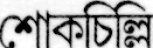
শোকচিল্লি
